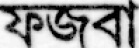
ফজবা
